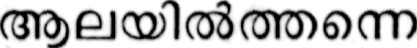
ആലയില്‍ത്തന്നെ
